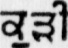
ਕੁੜੀ
